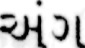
અંગ
